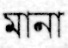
মানা
